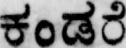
ಕಂಡರೆ
